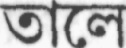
তালে
